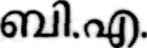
ബി.എ.
